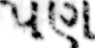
પણ
